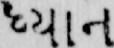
ધ્યાન
